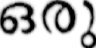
ഒരു
